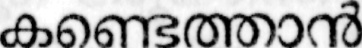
കണ്ടെത്താന്‍
